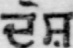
ਦੋਸ਼
